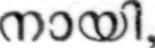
നായി,
